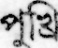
পুখ্রি
